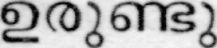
ഉരുണ്ടു
